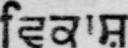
ਵਿਕਾਸ਼
